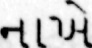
નાખે
